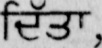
ਦਿੱਤਾ,
